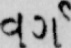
વર્ગ
